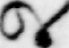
જ
